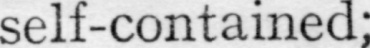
self-contained;
